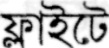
ফ্লাইটে
